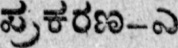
ಪ್ರಕರಣ-ಎ
